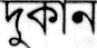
দুকান
